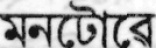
মনটোৱে
